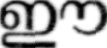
ഈ
